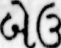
બેઉ
